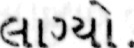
લાગ્યો.
